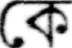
কে
